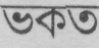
ভকত
